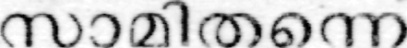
സാമിതന്നെ
